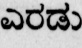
ಎರಡು
